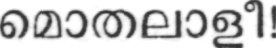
മൊതലാളീ!
